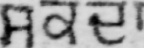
ਸਕਦਾ
